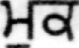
ਮੁਕ
